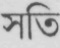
সতি
